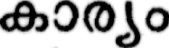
കാര്യം
